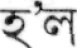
হ'ল
